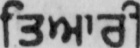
ਤਿਆਰੀ
